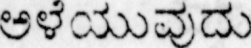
ಅಳೆಯುವುದು
